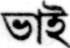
ভাই
